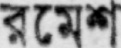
রমেশ
